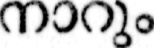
നാറും
